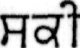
ਸਕੀ
